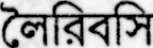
লৈরিবসি
